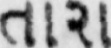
તારા
